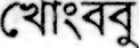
খোংববু
